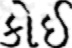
કોઈ
